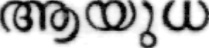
ആയുധ
